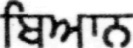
ਬਿਆਨ
